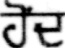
ਹੋਂਦ
